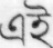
এই
